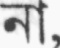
না,
